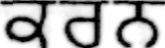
ਕਰਨ
